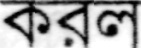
করল
